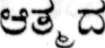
ಆತ್ಮದ
